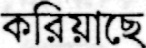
করিয়াছে
